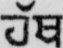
ਹੱਥ
